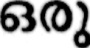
ഒരു
